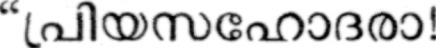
"പ്രിയസഹോദരാ!
